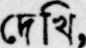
দেখি,
